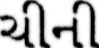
ચીની
